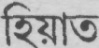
হিয়াত
